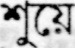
শুয়ে
